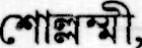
শোল্লম্মী,
